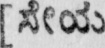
[ಸೇಯ
